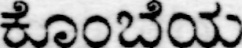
ಕೊಂಬೆಯ
